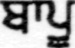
ਬਾਪੂ
